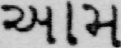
આમ
